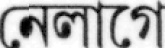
নেলাগে
